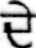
ਦੇ
